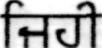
ਜਿਹੀ
